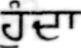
ਹੁੰਦਾ
